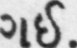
ગઈ.
